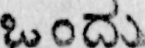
ಒಂದು
